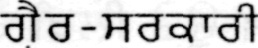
ਗ਼ੈਰ-ਸਰਕਾਰੀ
